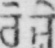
ਰੋਜ਼ੇ
